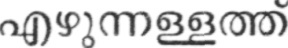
എഴുന്നള്ളത്ത്
